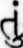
તું
